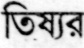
তিষ্যর
